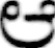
ಆ
